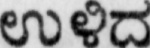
ಉಳಿದ
